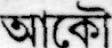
আকৌ
